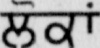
ਲੋਕਾਂ
